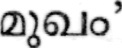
മുഖം'
